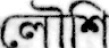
লৌশি
